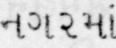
નગરમાં
